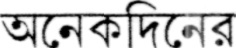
অনেকদিনের
